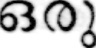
ഒരു
